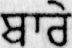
ਬਾਰੇ
